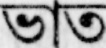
ভাত
